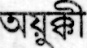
অয়ুক্কী
